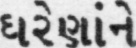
ઘરેણાંને
